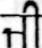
ਜੀ
